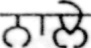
ਨਾਲੇ
